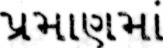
પ્રમાણમાં
